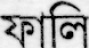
ফালি
